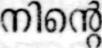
നിന്റെ
